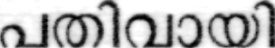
പതിവായി
